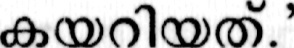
കയറിയത്.’
